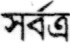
সর্বত্র
